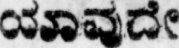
ಯಾವುದೇ
